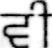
ਵੀ
